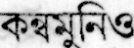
কন্বমুনিও
